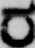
ರ
